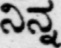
ನಿನ್ನ
